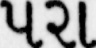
પરા
